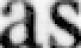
as
